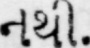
નથી.
